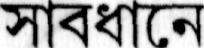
সাবধানে
